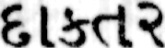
દાક્તર
